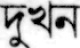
দুখন
